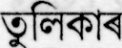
তুলিকাৰ
